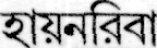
হায়নরিবা
